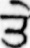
ਤੇ
